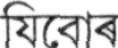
যিবোৰ
